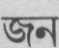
জন
